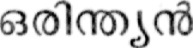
ഒരിന്ത്യന്‍
